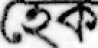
হেক
